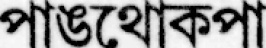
পাঙথোকপা
